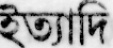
ইত্যাদি
